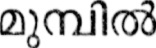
മുമ്പില്‍
